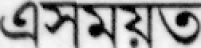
এসময়ত
